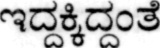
ಇದ್ದಕ್ಕಿದ್ದಂತೆ
